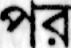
পর
